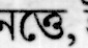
নত্তে,
